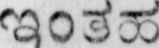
ಇಂತಹ
